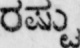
ರಷ್ಟು
